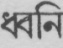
ধ্বনি
